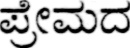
ಪ್ರೇಮದ
